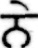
ਨੇ
